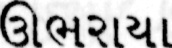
ઊભરાયા
